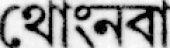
থোংনবা
